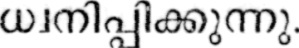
ധ്വനിപ്പിക്കുന്നു.
